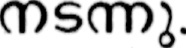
നടന്നു.
